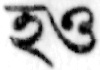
হও
